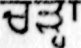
ਚੜ੍ਹਾ
